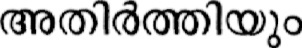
അതിര്‍ത്തിയും
